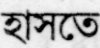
হাসতে
